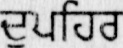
ਦੁਪਹਿਰ
